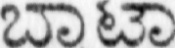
ಬಾಟಾ
